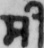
ਸੀ
